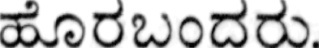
ಹೊರಬಂದರು.
